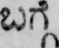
ಬಗ್ಗೆ
